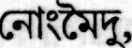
নোংমৈদু,
